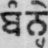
ਬੰਨ੍ਹੇ
